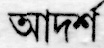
আদর্শ
